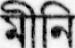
মীনি
